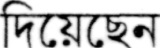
দিয়েছেন
